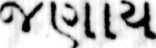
જણાય
